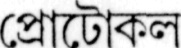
প্রোটোকল
